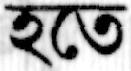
হতে
